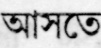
আসতে
